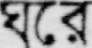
ঘরে
